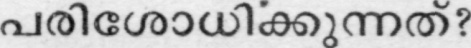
പരിശോധിക്കുന്നത്?
